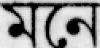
মনে
